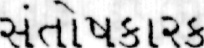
સંતોષકારક
